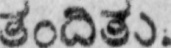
ತಂದಿತು.
